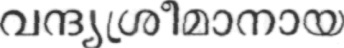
വന്ദ്യശ്രീമാനായ
